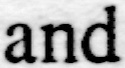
and
